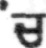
'ਚ
